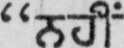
''ਨਹੀਂ
